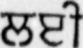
ਲਈ
